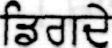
ਡਿਗਦੇ
